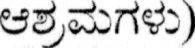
ಆಶ್ರಮಗಳು)
